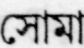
সোমা
